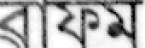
ৱাফম
